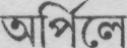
অর্পিলে
